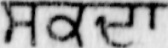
ਸਕਦਾ
